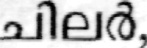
ചിലര്‍,
